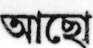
আছো
